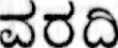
ವರದಿ
